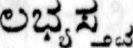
ಲಭ್ಯಸ್ತ್ವ
